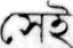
সেই
